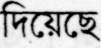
দিয়েছে
